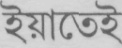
ইয়াতেই
